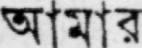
আমার
